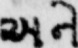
અને
